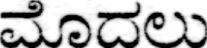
ಮೊದಲು
